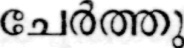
ചേര്‍ത്തു
